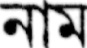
নাম
